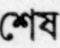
শেষ
